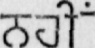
ਨਹੀਂ
